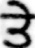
ਤੇ
